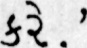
કરે.'
